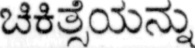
ಚಿಕಿತ್ಸೆಯನ್ನು
